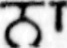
ਨਾ
